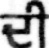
ਦੀ
